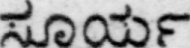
ಸೂರ್ಯ
